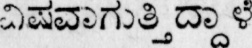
ವಿಷವಾಗುತ್ತಿದ್ದಾಳೆ
